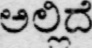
ಅಲ್ಲಿದೆ
